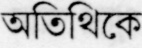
অতিথিকে
